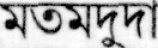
মতমদুদা
